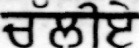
ਚੱਲੀਏ
